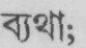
ব্যথা;
